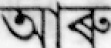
আৰু
